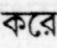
করে
